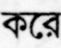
করে
